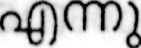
എന്നു
